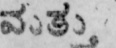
ಮತ್ತು
